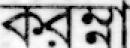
করম্না
